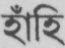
হাঁহি
